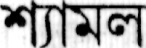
শ্যামল
